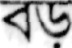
বড়
